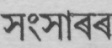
সংসাৰৰ
